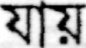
যায়
